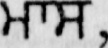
ਮਾਸ,
